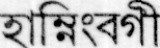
হাম্নিংবগী
